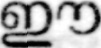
ഈ
